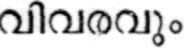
വിവരവും
